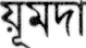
য়ূমদা
